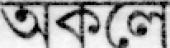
অকলে
